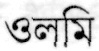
ওলমি
